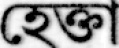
হেক্তা
